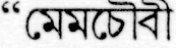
“মেমচৌবী
